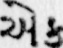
એક
